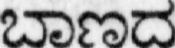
ಬಾಣದ
